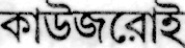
কাউজরোই
